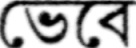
ভেবে
